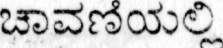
ಚಾವಣಿಯಲ್ಲಿ
